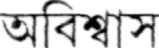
অবিশ্বাস
